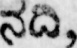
ನದಿ,
